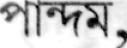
পান্দম,
